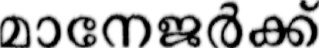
മാനേജര്‍ക്ക്
